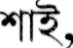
শাই,
